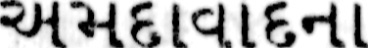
અમદાવાદના
